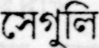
সেগুলি
